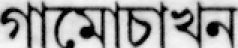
গামোচাখন
